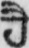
ਹੈ
